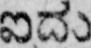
ಐದು
